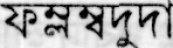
ফম্লম্বদুদা
